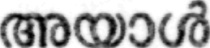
അയാള്‍
